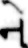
ને
